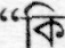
"কি
